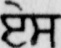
ਏਸ
